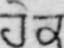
ਹੇਕ
